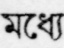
মধ্যে
